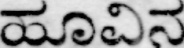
ಹೂವಿನ
